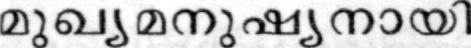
മുഖ്യമനുഷ്യനായി
